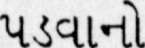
પડવાનો
